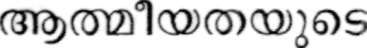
ആത്മീയതയുടെ
